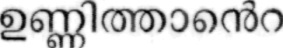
ഉണ്ണിത്താന്റെ
